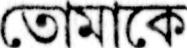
তোমাকে
